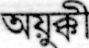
অয়ুক্কী
